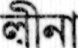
লীনা
